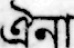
ঐনা
